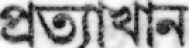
প্ৰত্যাখান
